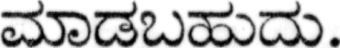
ಮಾಡಬಹುದು.
